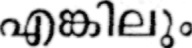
എങ്കിലും
